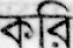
করি
